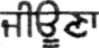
ਜੀਊਣਾ
